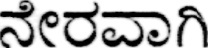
ನೇರವಾಗಿ
